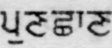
ਪੁਣਛਾਣ
